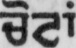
ਚੋਟਾਂ
